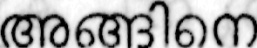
അങ്ങിനെ
